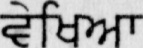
ਵੇਖਿਆ
